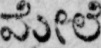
ಮೇಲೆ
